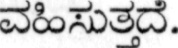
ವಹಿಸುತ್ತದೆ.
